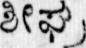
ಶೀಘ್ರ
